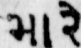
મારે
